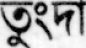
তুংদা
